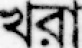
খরা
